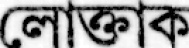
লোক্তাক
